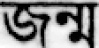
জন্ম
